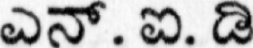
ಎನ್.ಐ.ಡಿ
